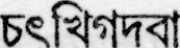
চৎখিগদবা
